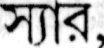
স্যার,
